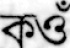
কওঁ
